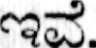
ಇವೆ.
